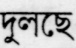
দুলছে
